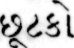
છૂટકો
